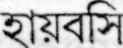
হায়বসি
